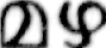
മഴ
